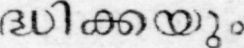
ദ്ധിക്കയും
